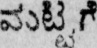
ಮಟ್ಟಿಗೆ
